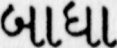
બાધા
